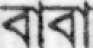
বাবা
